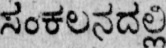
ಸಂಕಲನದಲ್ಲಿ
